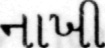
નાખી
